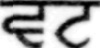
ਵਟ
